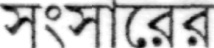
সংসারের
